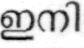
ഇനി
